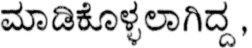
ಮಾಡಿಕೊಳ್ಳಲಾಗಿದ್ದ,
